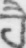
ਹੈ
